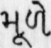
મૂળ
